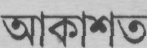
আকাশত
